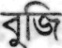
বুজি
